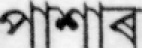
পাশাৰ
